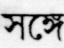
সঙ্গে
